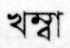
খম্বা
